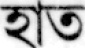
হাত
